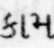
કામ
